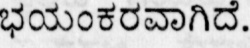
ಭಯಂಕರವಾಗಿದೆ.
